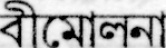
বীমোলনা
